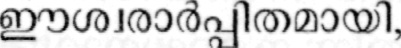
ഈശ്വരാര്‍പ്പിതമായി,
